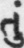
તું
